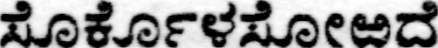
ಸೊರ್ಕೊಳಸೋಱದೆ
